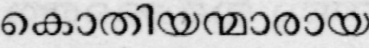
കൊതിയന്മാരായ
